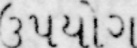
ઉપયોગ
